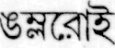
ঙম্লরোই
